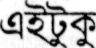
এইটুকু
